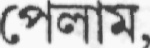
পেলাম,
